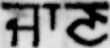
ਜਾਣ
